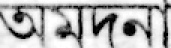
অমদনা
